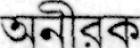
অনীরক
